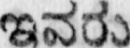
ಇವರು
